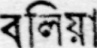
বলিয়া
